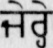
ਜੇਰ੍ਹੇ
